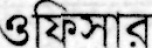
ওফিসার
